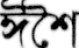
ঈশৈ
